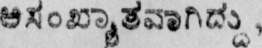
ಅಸಂಖ್ಯಾತವಾಗಿದ್ದು,
